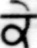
ਕੇ
